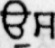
ਉਸ
